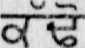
ਕੱਢੋ
